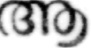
ആ
